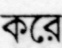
করে
